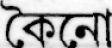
কৈনো
